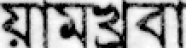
য়ামখ্রবা
